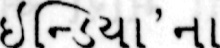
ઈન્ડિયા'ના
